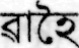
ৱাহৈ
